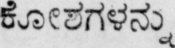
ಕೋಶಗಳನ್ನು
